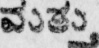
ಮತ್ತು
